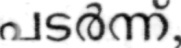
പടര്‍ന്ന്,
